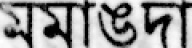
মমাঙদা
